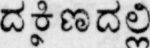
ದಕ್ಷಿಣದಲ್ಲಿ
